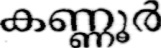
കണ്ണൂര്‍
